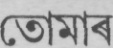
তোমাৰ
